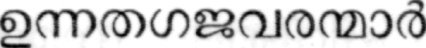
ഉന്നതഗജവരന്മാര്‍
